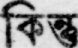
কিন্তু
